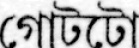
গোটটো
